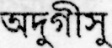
অদুগীসু
